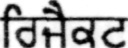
ਰਿਜੈਕਟ
